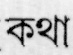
কথা
